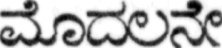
ಮೊದಲನೇ
